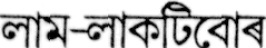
লাম-লাকটিবোৰ
